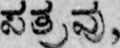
ಪತ್ರವು,
